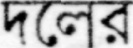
দলের
